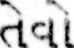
તેવો
